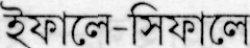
ইফালে-সিফালে
